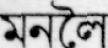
মনলৈ
